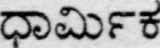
ಧಾರ್ಮಿಕ
